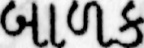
બાળક
